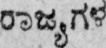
ರಾಜ್ಯಗಳ
